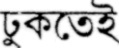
ঢুকতেই
